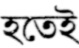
হতেই
